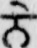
ਨੇ
